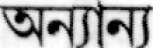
অন্যান্য
